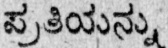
ಪ್ರತಿಯನ್ನು
